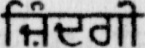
ਜ਼ਿੰਦਗੀ
